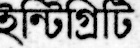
ইন্টিগ্রিটি
